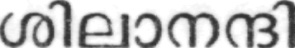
ശിലാനന്ദി
